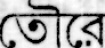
তৌরে
